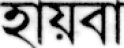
হায়বা
